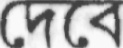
দেবে
